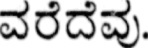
ವರೆದೆವು.
